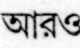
আরও
